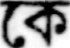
কে
